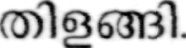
തിളങ്ങി.
